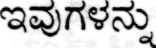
ಇವುಗಳನ್ನು
